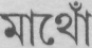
মাথোঁ
